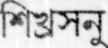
শিখ্রসনু
